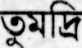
তুমদ্রি
